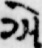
એ
